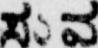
ಸುವ
